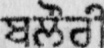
ਬਲੌਰੀ
